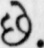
છે.
